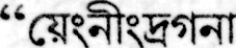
‘য়েংনীংদ্রগনা
